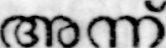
അന്ന്
